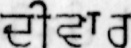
ਦੀਵਾਰ
